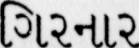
ગિરનરા
